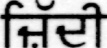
ਜ਼ਿੱਦੀ
